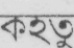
কহতু
